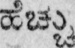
ಹೆಚ್ಚು
